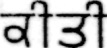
ਕੀਤੀ
